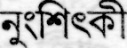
নুংশিৎকী
